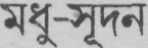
মধু-সূদন
